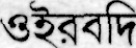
ওইরবদি
